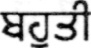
ਬਹੁਤੀ
